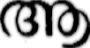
ആ
